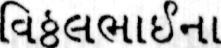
વિઠ્ઠલભાઈના
